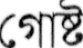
গোষ্ট
